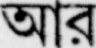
আর
